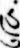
હું
